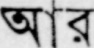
আর
